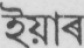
ইয়াৰ
